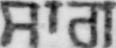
ਸਾਗ
